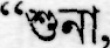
"শুনা,
